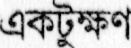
একটুক্ষণ
